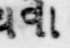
થવો
